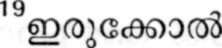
19ഇരുക്കോല്‍
